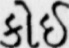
કોઈ
